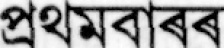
প্রথমবাৰৰ
